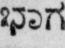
ಭಾಗ
